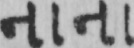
નાના
